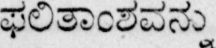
ಫಲಿತಾಂಶವನ್ನು
